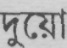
দুয়ো
